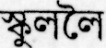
স্কুললৈ
